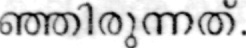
ഞ്ഞിരുന്നത്.
